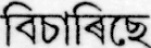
বিচাৰিছে
